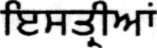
ਇਸਤ੍ਰੀਆਂ
